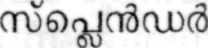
സ്പ്ലെന്‍ഡര്‍
